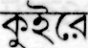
কুইরে
